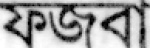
ফজবা
